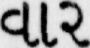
વાર
